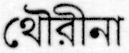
থৌরীনা
